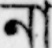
না
